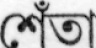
শেঁতা
